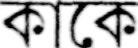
কাকে
